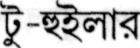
টু-হুইলার
